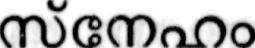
സ്നേഹം
